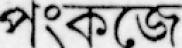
পংকজে
